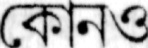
কোনও
